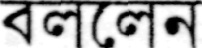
বললেন
